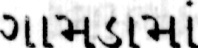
ગામડામાં
